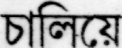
চালিয়ে
